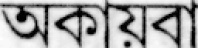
অকায়বা
